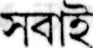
সবাই
